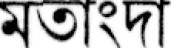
মতাংদা
